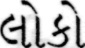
લોકો
